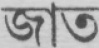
জাত
